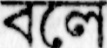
বলে
